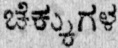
ಚೆಕ್ಕುಗಳ
